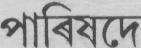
পাৰিষদে
